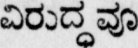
ವಿರುದ್ಧವೂ
